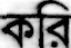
করি
